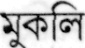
মুকলি
